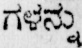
ಗಳನ್ನು
